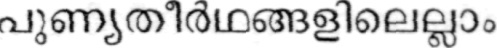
പുണ്യതീര്‍ഥങ്ങളിലെല്ലാം
